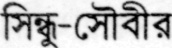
সিন্ধু-সৌবীর
